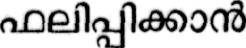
ഫലിപ്പിക്കാന്‍
